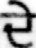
ਦੇ
